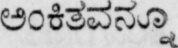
ಅಂಕಿತವನ್ನೂ
